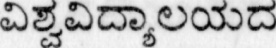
ವಿಶ್ವವಿದ್ಯಾಲಯದ
